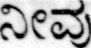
ನೀವು
